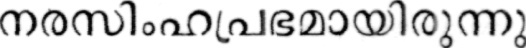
നരസിംഹപ്രഭമായിരുന്നു
